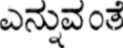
ಎನ್ನುವಂತೆ
